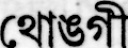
থোঙগী
